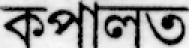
কপালত
